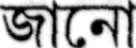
জানো
